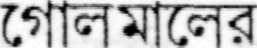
গোলমালের
